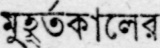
মুহূর্তকালের
